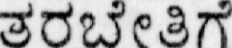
ತರಬೇತಿಗೆ
